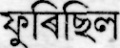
ফুৰিছিল
